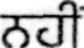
ਨਹੀਂ
